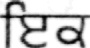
ਇਕ
